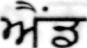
ਐਂਡ
